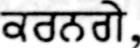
ਕਰਨਗੇ,
